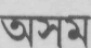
অসম
